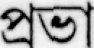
প্রভা
